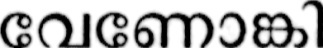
വേണോങ്കി
